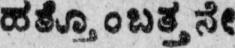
ಹತ್ತೊಂಬತ್ತನೇ
